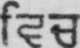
ਵਿਚ
